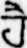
ਹੈ
